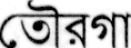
তৌরগা
